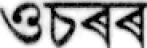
ওচৰৰ
